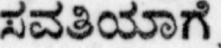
ಸವತಿಯಾಗೆ
